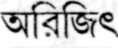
অরিজিৎ
